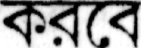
করবে
